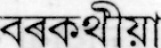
বৰকথীয়া
